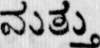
ಮತ್ತು
